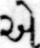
એ
